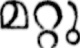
മറ്റു
